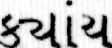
ક્યાંય
